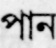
পান
